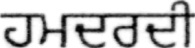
ਹਮਦਰਦੀ
